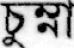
চুম্না
